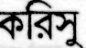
করিসু
